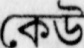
কেউ
